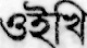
ওইখি
